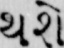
થશે
